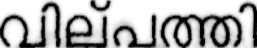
വില്പത്തി
